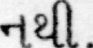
નથી.
